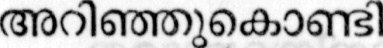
അറിഞ്ഞുകൊണ്ടി
